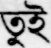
তুই
